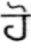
ਹੋ
